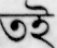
তই
